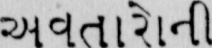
અવતારોની
